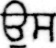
ਉਸ
